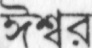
ঈশ্বর
